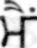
ਮੈਂ
